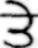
ਤੇ
